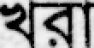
খরা
